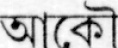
আকৌ
